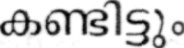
കണ്ടിട്ടും
